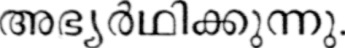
അഭ്യര്‍ഥിക്കുന്നു.
